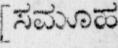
[ಸಮೂಹ
